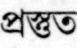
প্রস্তুত
